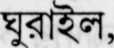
ঘুরাইল,
